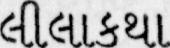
લીલાકથા
